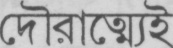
দৌরাত্ম্যেই
